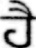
ਹੈ
